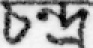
চন্দ্র
